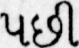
પછી
